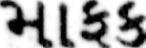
માફક
